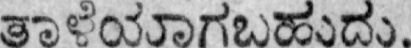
ತಾಳೆಯಾಗಬಹುದು.
